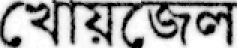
খোয়জেল
